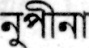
নুপীনা
